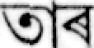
তাৰ
